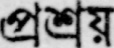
প্রশ্রয়
